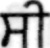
ਸੀ
